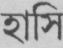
হাসি
